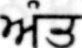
ਅੰਤ
